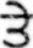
ਤੇ
